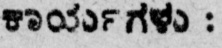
ಕಾರ್ಯಗಳು:
